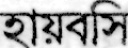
হায়বসি
